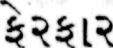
ફેરફાર
